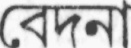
বেদনা
